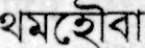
থমহৌবা
